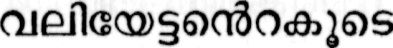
വലിയേട്ടന്റെകൂടെ
